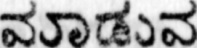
ಮಾಡುವ
